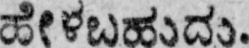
ಹೇಳಬಹುದು.
